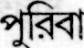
পুরিবা
